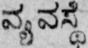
ವ್ಯವಸ್ಥೆ
